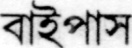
বাইপাস
